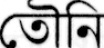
তৌনি
